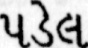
પડેલ
